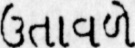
ઉતાવળે
